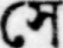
সে
